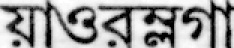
য়াওরম্লগা
